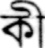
কী
